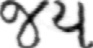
જય
